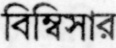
বিম্বিসার
